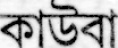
কাউবা
